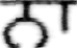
ਨਾ
